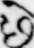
છે
